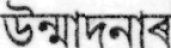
উন্মাদনাৰ
